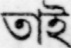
তাই
